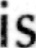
is
